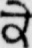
ਕੇ
